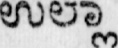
ಉಲ್ಲಾ
